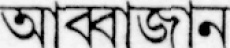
আব্বাজান
